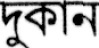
দুকান
